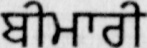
ਬੀਮਾਰੀ
